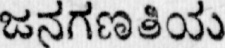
ಜನಗಣತಿಯ
